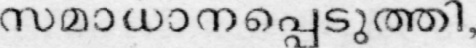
സമാധാനപ്പെടുത്തി,
